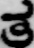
ತ
